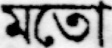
মতো
